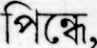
পিন্ধে,
